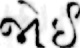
જોઈ
